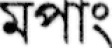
মপাং
